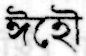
ঈহৌ
